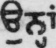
ਉਨ੍ਹਾਂ
